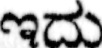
ಇದು
